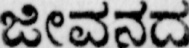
ಜೀವನದ
